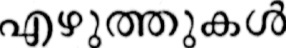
എഴുത്തുകള്‍
